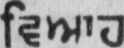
ਵਿਆਹ
